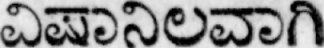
ವಿಷಾನಿಲವಾಗಿ
